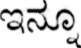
ಇನ್ನೂ
